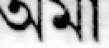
অমা
